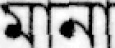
মানা
